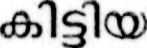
കിട്ടിയ
